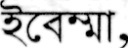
ইবেম্মা,
